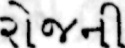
રોજની
